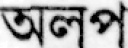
অলপ
